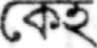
কেহ
